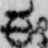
ಈ
